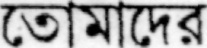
তোমাদের
